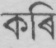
কৰি
